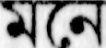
মনে
